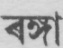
ৰঙ্গা
